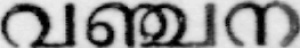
വഞ്ചന
